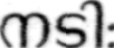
നടി:
